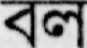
বল
